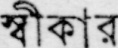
স্বীকার
